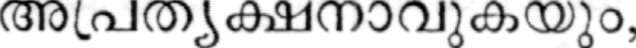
അപ്രത്യക്ഷനാവുകയും,
